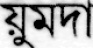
য়ুমদা
